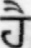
ਹੈ
